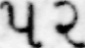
પર
